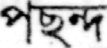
পছন্দ
